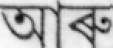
আৰু
